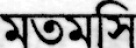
মতমসি
